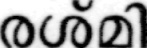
രശ്മി
